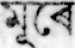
মূৰে
